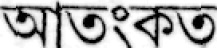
আতংকত
